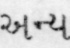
અન્ય
